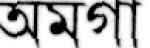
অমগা
